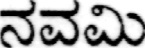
ನವಮಿ
